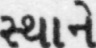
સ્થાને
